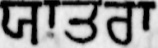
ਯਾਤਰਾ
